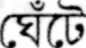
ঘেঁটে
